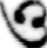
ও
